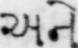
અને
